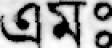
এমঃ
